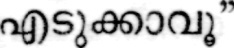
എടുക്കാവൂ”
